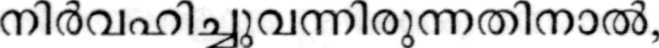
നിര്‍വഹിച്ചുവന്നിരുന്നതിനാല്‍,
